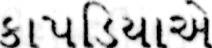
કાપડિયાએ
